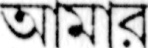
আমার
